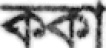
ককা
